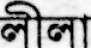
লীলা
